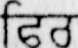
ਫਿਰ
